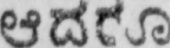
ಆದರೂ
